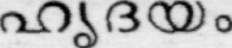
ഹൃദയം
